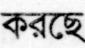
করছে
